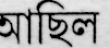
আছিল
